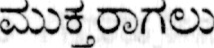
ಮುಕ್ತರಾಗಲು
